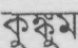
কুঙ্কুম
